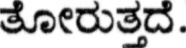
ತೋರುತ್ತದೆ.
